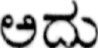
ಅದು
